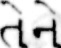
તેને
